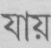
যায়
